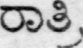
ರಾತ್ರಿ
